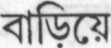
বাড়িয়ে
